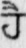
ਹੈ
